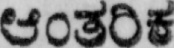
ಆಂತರಿಕ
